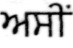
ਅਸੀਂ
